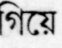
গিয়ে
